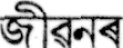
জীৱনৰ
